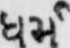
ધર્મ
